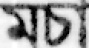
মচা
